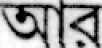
আর
